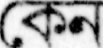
কেন
